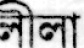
লীলা
